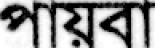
পায়বা
